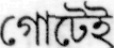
গোটেই
